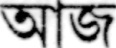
আজ
